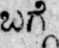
ಬಗ್ಗೆ
